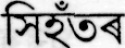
সিহঁতৰ
